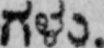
ಗಳು.
